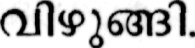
വിഴുങ്ങി.
